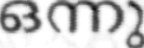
ഒന്നു
